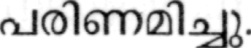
പരിണമിച്ചു.
